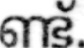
ണ്ട്.
